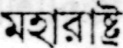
মহারাষ্ট্র
